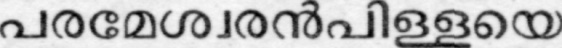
പരമേശ്വരന്‍പിള്ളയെ
